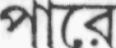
পারে
